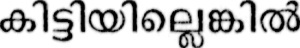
കിട്ടിയില്ലെങ്കില്‍
